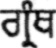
ਗ੍ਰੰਥ
